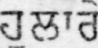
ਹੁਲਾਰੇ
